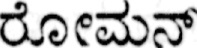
ರೋಮನ್
